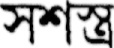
সশস্ত্র
